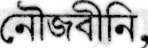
নৌজবীনি,
